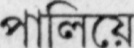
পালিয়ে
